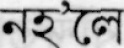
নহ'লে
